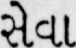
સેવા
